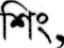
শিং,
